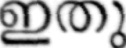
ഇതു
